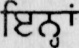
ਇਨ੍ਹਾਂ
